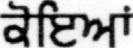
ਕੋਇਆਂ
